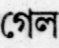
গেল
